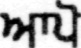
ਆਪੋ
